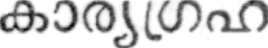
കാര്യഗ്രഹ
